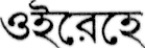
ওইরেহে
